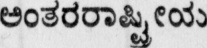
ಅಂತರರಾಷ್ಟ್ರೀಯ
